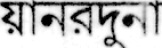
য়ানরদুনা
